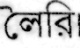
লৈরি।
